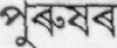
পুৰুষৰ
